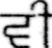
ਵੀ
